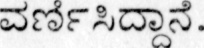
ವರ್ಣಿಸಿದ್ದಾನೆ.
